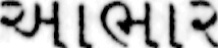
આભાર
